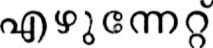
എഴുന്നേറ്റ്
